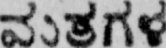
ಮತಗಳ
